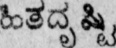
ಹಿತದೃಷ್ಟಿ
